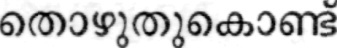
തൊഴുതുകൊണ്ട്
